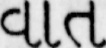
વાત
